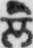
ਲੈ
